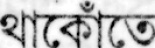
থাকোঁতে
